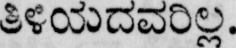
ತಿಳಿಯದವರಿಲ್ಲ.
